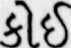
કોઈ
